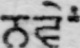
ਨਵੇਂ
